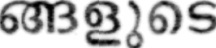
ങ്ങളുടെ
